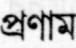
প্রণাম
